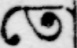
তো
